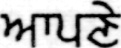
ਆਪਣੇ
